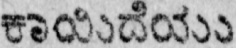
ಕಾಯಿದೆಯು
